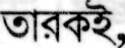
তরকই,
